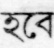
হবে
